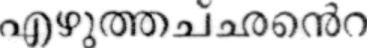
എഴുത്തച്ഛന്റെ
